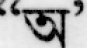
"অ'
